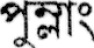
পুম্লাং
